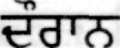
ਦੌਰਾਨ
